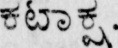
ಕಟಾಕ್ಷ.
